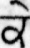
ਕੇ
